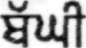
ਬੱਘੀ
